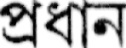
প্রধান
